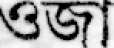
ওজা
